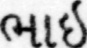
ભાઈ
